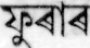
ফুৰাৰ
